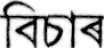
বিচাৰ
